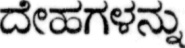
ದೇಹಗಳನ್ನು
